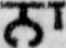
ਨਾ
